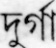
দুর্গা
